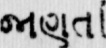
જાણતાં
